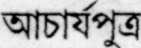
আচার্যপুত্র
